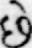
છે
